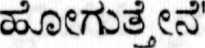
ಹೋಗುತ್ತೇನೆ
